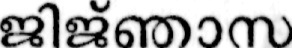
ജിജ്ഞാസ
